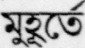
মুহূর্তে
